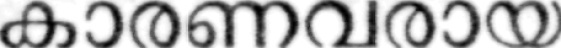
കാരണവരായ
